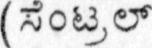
(ಸೆಂಟ್ರಲ್
